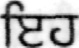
ਇਹ
